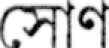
সোণ
